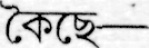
কৈছে-
